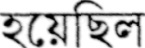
হয়েছিল
